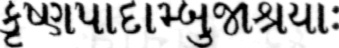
કૃષ્ણપાદામ્બુજાશ્રયાઃ
